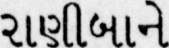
રાણીબાને
